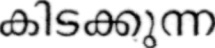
കിടക്കുന്ന
